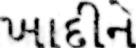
ખાદીને
